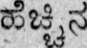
ಹೆಚ್ಚಿನ
